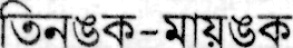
তিনঙক-মায়ঙক
